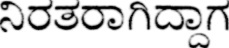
ನಿರತರಾಗಿದ್ದಾಗ
